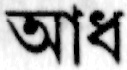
আধ
